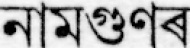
নামগুণৰ
